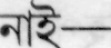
নাই-
